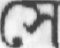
সে
